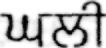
ਘਲੀ
